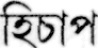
হিচাপ
